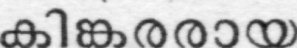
കിങ്കരരായ
